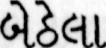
બેઠેલા
